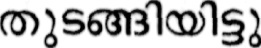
തുടങ്ങിയിട്ടു
